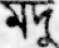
মদু
